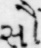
સૌ
